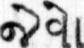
જેવો
